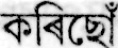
কৰিছোঁ
